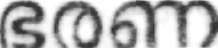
ഭരണ
